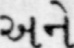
અને
